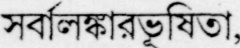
সর্বালঙ্কারভূষিতা,
